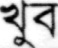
খুব
